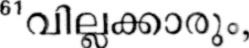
61വില്ലക്കാരും,
